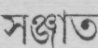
সঞ্জাত
